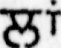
ਲਾਂ
